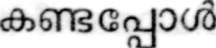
കണ്ടപ്പോള്‍
